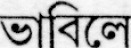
ভাবিলে
